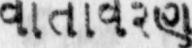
વાતાવરણ
